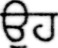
ਉਹ
